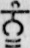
ਨੂੰ
